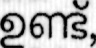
ഉണ്ട്,
